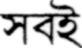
সবই
